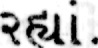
રહ્યાં.
